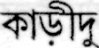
গাড়ীদু
